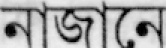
নাজানে
